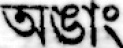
অঙাং
